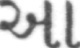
આ
